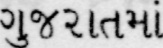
ગુજરાતમાં
